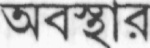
অবস্থার
